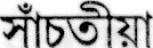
সাঁচতীয়া
